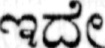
ಇದೇ
